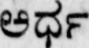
ಅರ್ಧ
